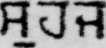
ਸੁਹਜ
